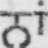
ਨਾਂ
